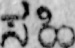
ಸಹಿ
